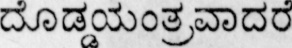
ದೊಡ್ಡಯಂತ್ರವಾದರೆ
